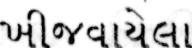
ખીજવાયેલા
